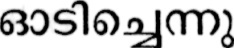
ഓടിച്ചെന്നു
